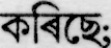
কৰিছে;
